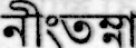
নীংতম্না
